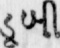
ડૂંબી
